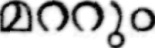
മററും
